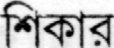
শিকার
